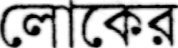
লোকের
